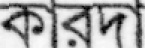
কারদা
